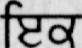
ਇਕ
